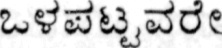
ಒಳಪಟ್ಟವರೇ
